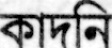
কাদনি
